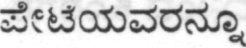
ಪೇಟೆಯವರನ್ನೂ
